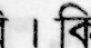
ইপান
